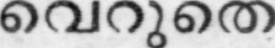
വെറുതെ
